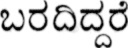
ಬರದಿದ್ದರೆ
